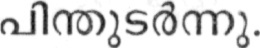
പിന്തുടര്‍ന്നു.
